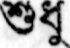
শুধু
